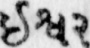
ઇશ્વર
